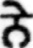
ਨੇ
